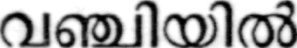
വഞ്ചിയില്‍
